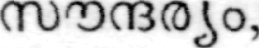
സൌന്ദര്യം,
